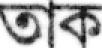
তাক
